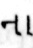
ના
